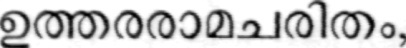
ഉത്തരരാമചരിതം,
